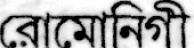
রোমোনিগী
